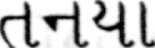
તનયા
